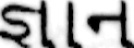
જ્ઞાન
